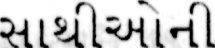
સાથીઓની
